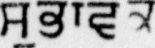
ਸੁਭਾਵਕ
